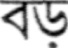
বড়
